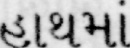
હાથમાં
